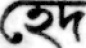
হেদ
